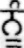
ਨੂੰ
